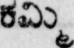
ಕಮ್ಮಿ
